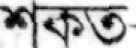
শকত
